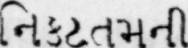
નિકટતમની
